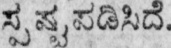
ಸ್ಪಷ್ಟಪಡಿಸಿದೆ.
